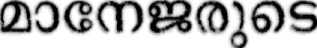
മാനേജരുടെ
